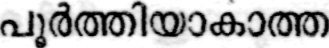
പൂര്‍ത്തിയാകാത്ത
